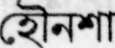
হৌনশা
